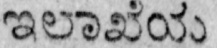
ಇಲಾಖೆಯ
